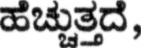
ಹೆಚ್ಚುತ್ತದೆ,
